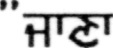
''ਜਾਣਾ
